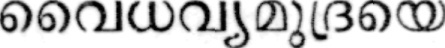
വൈധവ്യമുദ്രയെ
